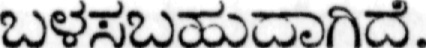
ಬಳಸಬಹುದಾಗಿದೆ.
